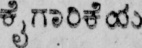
ಕೈಗಾರಿಕೆಯ
